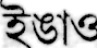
ইঙাও
